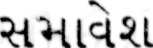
સમાવેશ
